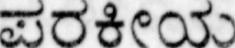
ಪರಕೀಯ
